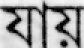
যায়
